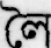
লৈ
